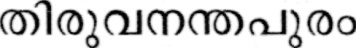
തിരുവനന്തപുരം
